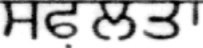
ਸਫ਼ਲਤਾ
